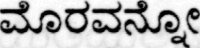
ಮೊರವನ್ನೋ
